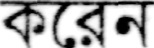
করেন
